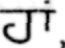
ਹਾਂ,
